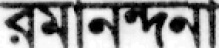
রমানন্দনা
